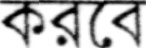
করবে
